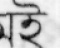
মই
